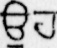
ਉਹ
